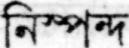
নিস্পন্দ
